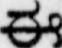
ಈ
